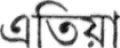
এতিয়া
